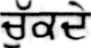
ਚੁੱਕਦੇ
